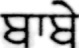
ਬਾਬੇ
